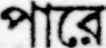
পারে
